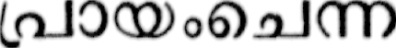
പ്രായംചെന്ന
